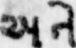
અને
